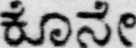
ಕೊನೇ
